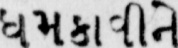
ધમકાવીને
